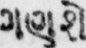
ગણશે
